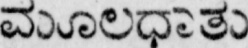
ಮೂಲಧಾತು
